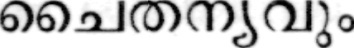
ചൈതന്യവും
